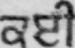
ਕਈ
